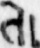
તો
